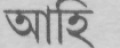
আহি
